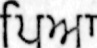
ਪਿਆ
